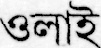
ওলাই
